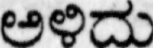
ಅಳಿದು
